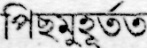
পিছমুহূর্তত
